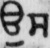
ਉਸ
